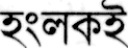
হংলকই
